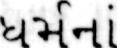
ધર્મના
